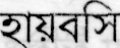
হায়বসি
